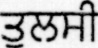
ਤੁਲਸੀ
